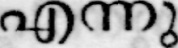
എന്നു
